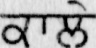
ਕਾਲੇ
